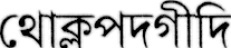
থোক্লপদগীদি
